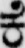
ಕೆ
